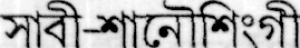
সাবী-শানৌশিংগী
